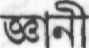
জ্ঞানী
